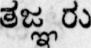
ತಜ್ಞರು
